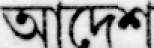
আদেশ
